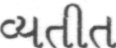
વ્યતીત
